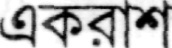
একরাশ
